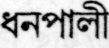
ধনপালী
